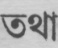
তথা
